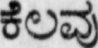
ಕೆಲವು
